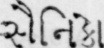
સૈનિકો
